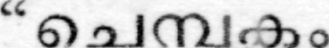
"ചെമ്പകം
